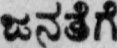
ಜನತೆಗೆ
